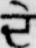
ਦੇ
